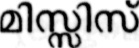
മിസ്സിസ്
